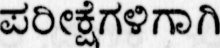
ಪರೀಕ್ಷೆಗಳಿಗಾಗಿ
